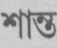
শান্ত
